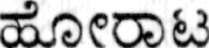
ಹೋರಾಟ
